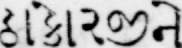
ઠાકોરજીને
